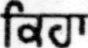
ਕਿਹਾ
